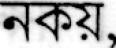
নকয়,
